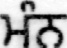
ਮੰਨ
